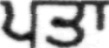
ਪਤਾ
